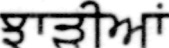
ਝਾੜੀਆਂ
